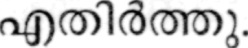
എതിര്‍ത്തു.
